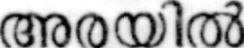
അരയില്‍
